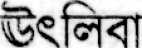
ঊৎলিবা
